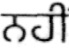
ਨਹੀਂ
